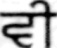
ਵੀ
